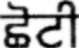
ਛੋਟੀ
